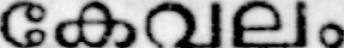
കേവലം
